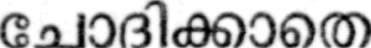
ചോദിക്കാതെ
